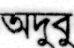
অদুবু
